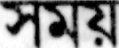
সময়
